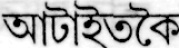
আটাইতকৈ
